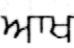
ਆਖ
